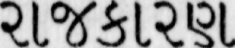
રાજકારણ
